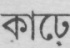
কাঢ়ে
